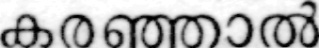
കരഞ്ഞാല്‍
